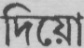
দিয়ো
